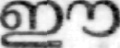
ഈ
